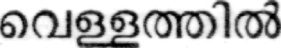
വെള്ളത്തില്‍
